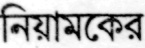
নিয়ামকের
